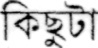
কিছুটা
